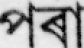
পৰা
